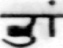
ਤਾਂ
